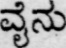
ವೈನು
